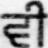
ਵੀ
